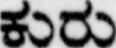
ಕುರು
